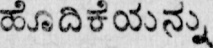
ಹೊದಿಕೆಯನ್ನು
